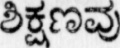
ಶಿಕ್ಷಣವು
